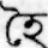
হৈ
